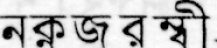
নক্নজরম্বী
